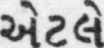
એટલે
